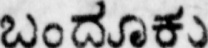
ಬಂದೂಕು
